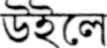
উইলে
